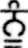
ਨੂੰ
